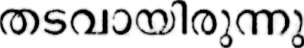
തടവായിരുന്നു
